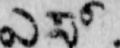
ಎಸ್.
